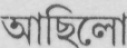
আছিলো
